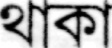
থাকা
